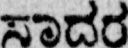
ಸಾದರ
